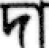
দা
